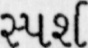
સ્પર્શ
